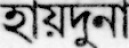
হায়দুনা
